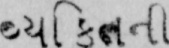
વ્યકિતની
